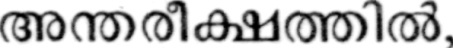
അന്തരീക്ഷത്തില്‍,
